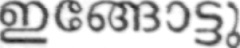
ഇങ്ങോട്ടു
